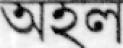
অহল
